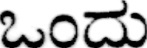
ಒಂದು
